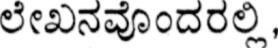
ಲೇಖನವೊಂದರಲ್ಲಿ,
